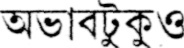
অভাবটুকুও
